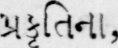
પ્રકુતિના,
